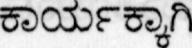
ಕಾರ್ಯಕ್ಕಾಗಿ
